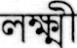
লক্ষ্মী
